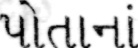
પોતાનાં
